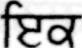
ਇਕ
